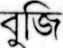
বুজি
